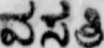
ವಸತಿ
